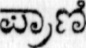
ಪ್ರಾಣಿ
